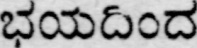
ಭಯದಿಂದ
